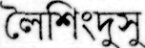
লৈশিংদুসু
